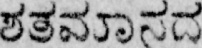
ಶತಮಾನದ
